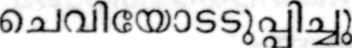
ചെവിയോടടുപ്പിച്ചു
